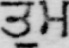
ਤੁਮ
